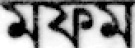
মফম
